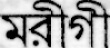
মরীগী
